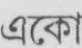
একো
